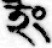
ইং
